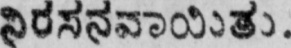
ನಿರಸನವಾಯಿತು.
